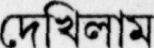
দেখিলাম
